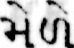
મેળે
